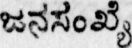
ಜನಸಂಖ್ಯೆ
